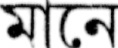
মানে
